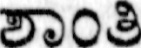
ಶಾಂತಿ
